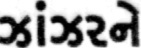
ઝાંઝરને
